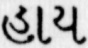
હાય
